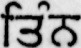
ਤਿੰਨ
